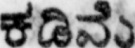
ಕಡಿಮೆ
